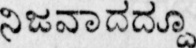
ನಿಜವಾದದ್ದೂ
